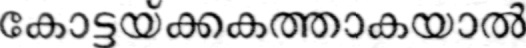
കോട്ടയ്ക്കകത്താകയാല്‍
